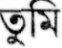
তুমি
